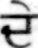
ਦੇ
